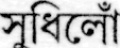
সুধিলোঁ
